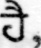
ਹੈ,
